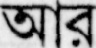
আর
